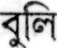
বুলি
